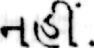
નહીં.
